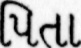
પિતા
